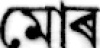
মোৰ
